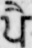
ਪੈ
